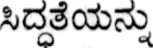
ಸಿದ್ಧತೆಯನ್ನು
